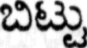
ಬಿಟ್ಟು
